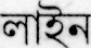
লাইন
